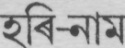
হৰি-নাম
